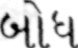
બોધ
